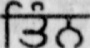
ਤਿੰਨ
